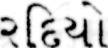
રદિયો
